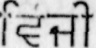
ਵਿਜੀ
